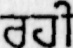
ਰਹੀ
